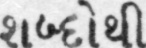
શબ્દોથી
